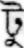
টু
